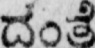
ದಂತೆ
